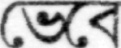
ভেবে
